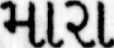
મારા
